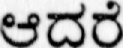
ಆದರೆ
